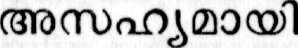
അസഹ്യമായി
